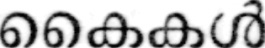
കൈകള്‍
